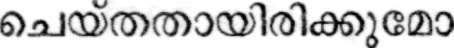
ചെയ്തതായിരിക്കുമോ
